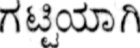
ಗಟ್ಟಿಯಾಗಿ
